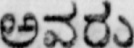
ಅವರು
